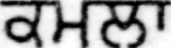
ਕਮਲਾ
